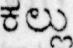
ಕಲ್ಲು
